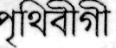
পৃথিবীগী
